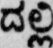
ದಲ್ಲಿ
